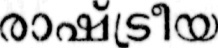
രാഷ്ട്രീയ
